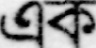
এক
